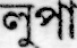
লুপা
